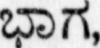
ಭಾಗ,
